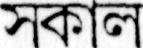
সকাল
